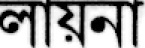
লায়না
